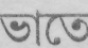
ভাতে
